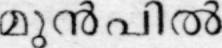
മുന്‍പില്‍
